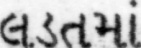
લડતમાં
